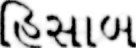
હિસાબ
